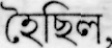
হৈছিল,
